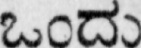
ಒಂದು
